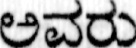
ಅವರು
